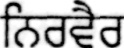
ਨਿਰਵੈਰ
